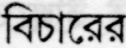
বিচারের
